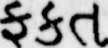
ફક્ત
